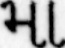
મા
